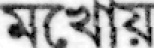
মখোয়
